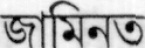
জামিনত
